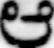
ಆ
